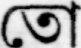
তো
